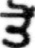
ਤੋਂ
